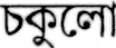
চকুলো
